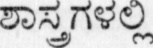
ಶಾಸ್ತ್ರಗಳಲ್ಲಿ
